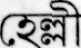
হেল্লী
